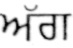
ਅੱਗ
